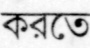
করতে
